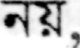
নয়,
